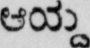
ಆಯ್ದ
